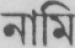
নামি
